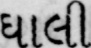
ઘાલી
